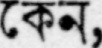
কেন,
